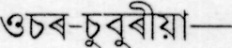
ওচৰ-চুবুৰীয়া-
